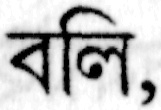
বলি,
